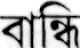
বান্ধি
